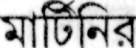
মার্টিনির
